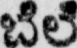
ಬೆಲೆ
